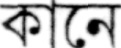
কানে
